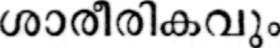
ശാരീരികവും
